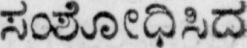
ಸಂಶೋಧಿಸಿದ
